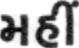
મહીં
